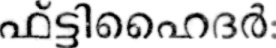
ഫ്ട്ടിഹൈദര്‍:
